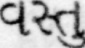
વસ્તુ
